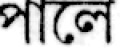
পালে
